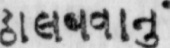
ઠાલવવાનું
